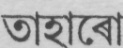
তাহাৰো
